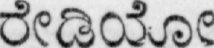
ರೇಡಿಯೋ
